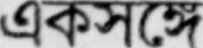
একসঙ্গে
